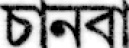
চানবা
